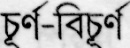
চূর্ণ-বিচূর্ণ
